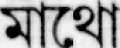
মাথো
